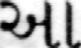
આ
